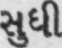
સુધી
